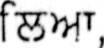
ਲਿਆ,
